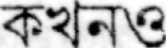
কখনও
